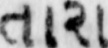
તારા
